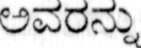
ಅವರನ್ನು
